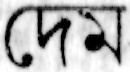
দেম
